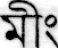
মীং
